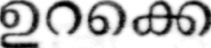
ഉറക്കെ
